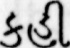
કહી
